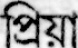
প্রিয়া
